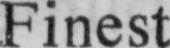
Finest
